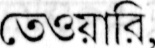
তেওয়ারি,
